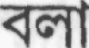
বলা
